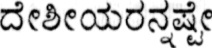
ದೇಶೀಯರನ್ನಷ್ಟೇ
